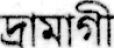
দ্রামাগী
